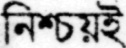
নিশ্চয়ই
